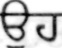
ਉਹ
